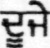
ਦੂਜੇ
